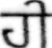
ਹੀ
